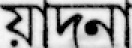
য়াদনা
